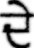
ਦੇ
